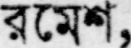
রমেশ,
